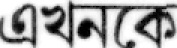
এখনকে
